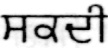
ਸਕਦੀ
